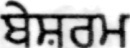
ਬੇਸ਼ਰਮ
